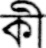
কী
